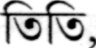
তিতি,
